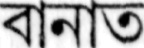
বানাত
